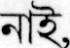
নাই,
